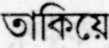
তাকিয়ে
